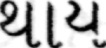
થાય
